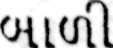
બાળી
